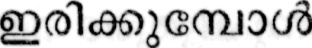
ഇരിക്കുമ്പോള്‍
